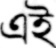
এই
